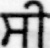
ਸੀ
